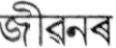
জীৱনৰ
